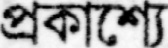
প্রকাশ্যে
